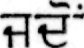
ਜਦੋਂ
